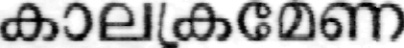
കാലക്രമേണ
